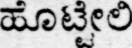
ಹೊಟ್ಟೇಲಿ
